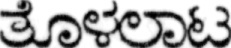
ತೊಳಲಾಟ
